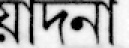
য়াদনা
